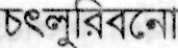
চৎলুরিবনো
